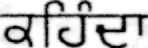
ਕਹਿੰਦਾ
